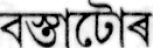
বস্তাটোৰ
